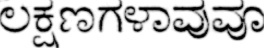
ಲಕ್ಷಣಗಳಾವುವೂ
